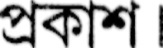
প্রকাশ।
